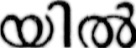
യില്‍
